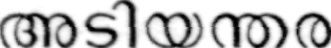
അടിയന്തര
